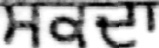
ਸਕਦਾ
